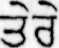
ਤੇਰੇ
